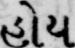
હોય
